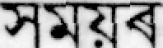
সময়ৰ
